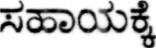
ಸಹಾಯಕ್ಕೆ
